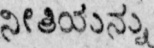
ನೀತಿಯನ್ನು
